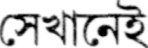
সেখানেই
